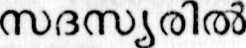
സദസ്യരില്‍
